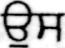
ਉਸ
